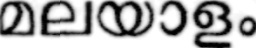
മലയാളം
